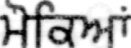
ਮੌਕਿਆਂ
